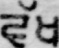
ਵੱਖ
